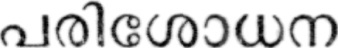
പരിശോധന
